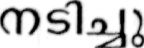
നടിച്ചു
